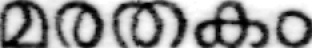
മരതകം
